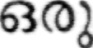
ഒരു
